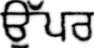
ਉੱਪਰ
